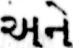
અને
